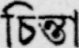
চিন্তা
